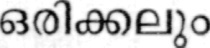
ഒരിക്കലും
